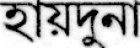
হায়দুনা
